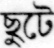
ছুটে
